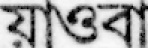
য়াওবা
